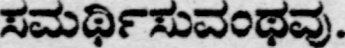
ಸಮರ್ಥಿಸುವಂಥವು.
